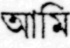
আমি
